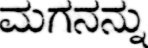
ಮಗನನ್ನು
